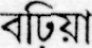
বঢ়িয়া
